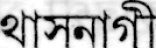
থাসনাগী
